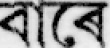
বাৰে
